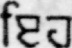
ਇਹ
